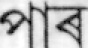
পাৰ
